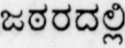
ಜಠರದಲ್ಲಿ
